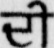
ਦੀ
